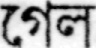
গেল
